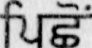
ਪਿਛੋਂ
